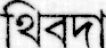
থিবদা
